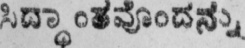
ಸಿದ್ಧಾಂತವೊಂದನ್ನು
